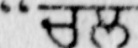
''ਚਲ
